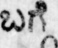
ಬಗ್ಗೆ
